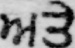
ਅਤੇ
